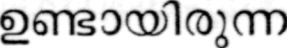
ഉണ്ടായിരുന്ന
